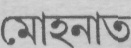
মোহনাত
